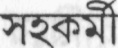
সহকর্মী
